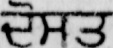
ਦੋਸਤ
